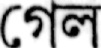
গেল
